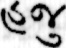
હજુ
